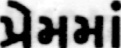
પ્રેમમાં
